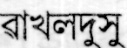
ৱাখলদুসু
